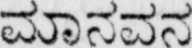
ಮಾನವನ
